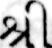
શ્રી
